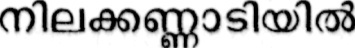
നിലക്കണ്ണാടിയില്‍
